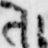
તો
